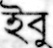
ইবু
